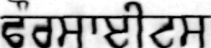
ਫੌਰਸਾਈਟਸ
